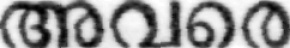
അവരെ
